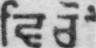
ਵਿਚੋਂ
